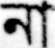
না
